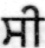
ਸੀ
